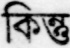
কিন্তু
